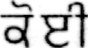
ਕੋਈ
